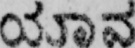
ಯಾವ
